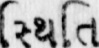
સ્થિતિ
